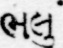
ભલું
